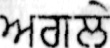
ਅਗਲੇ
